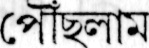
পৌঁছলাম
